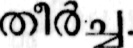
തീര്‍ച്ച.
